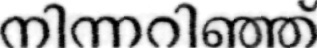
നിന്നറിഞ്ഞ്
